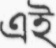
এই
